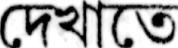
দেখাতে
